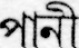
পানী
